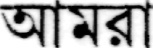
আমরা
